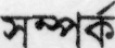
সম্পর্ক
